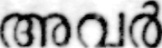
അവര്‍
